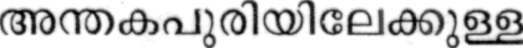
അന്തകപുരിയിലേക്കുള്ള
